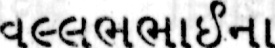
વલ્લભભાઈના
